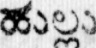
ಹುಲ್ಲು
